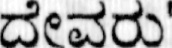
ದೇವರು!
